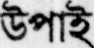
উপাই
